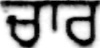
ਚਾਰ
